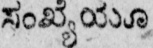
ಸಂಖ್ಯೆಯೂ
